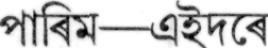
পাৰিম-এইদৰে
